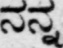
ನನ್ನ
